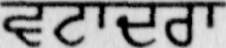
ਵਟਾਦਰਾ
